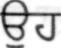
ਉਹ
